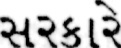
સરકારે
